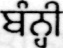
ਬੰਨ੍ਹੀ
